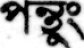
পন্থুং
